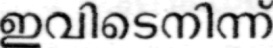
ഇവിടെനിന്ന്
